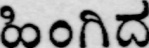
ಹಿಂಗಿದ
